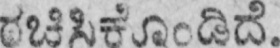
ರಚಿಸಿಕೊಂಡಿದೆ.
